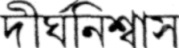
দীর্ঘনিশ্বাস
